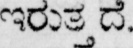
ಇರುತ್ತದೆ.
